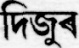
দিজুৰ
